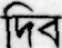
দিব
